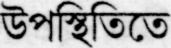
উপস্থিতিতে
